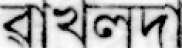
ৱাখলদা
